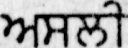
ਅਸਲੀ
